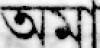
অমা
